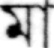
মা
